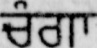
ਚੰਗਾ
